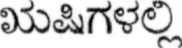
ಋಷಿಗಳಲ್ಲಿ
